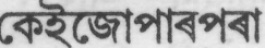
কেইজোপাৰপৰা
